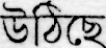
উঠিছে
